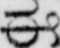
ಈ
